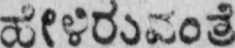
ಹೇಳಿರುವಂತೆ
